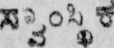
ಸ್ವಾಂಸ್ಥಿಕ
